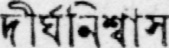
দীর্ঘনিশ্বাস
